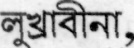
লুখ্রাবীনা,
